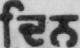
ਦਿਨ
